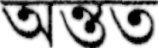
অন্তত
